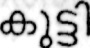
കുട്ടി
